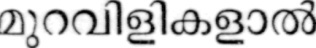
മുറവിളികളാല്‍
